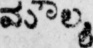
ಮೌಲ್ಯ
